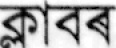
ক্লাবৰ
